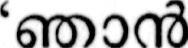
‘ഞാന്‍
